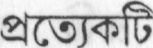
প্রত্যেকটি
